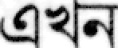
এখন
